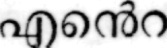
എന്റെ
